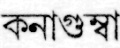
কনাগুম্বা
